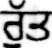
ਰੁੱਤ
